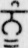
ਨੂੰ
